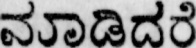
ಮಾಡಿದರೆ
